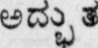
ಅದ್ಭುತ
